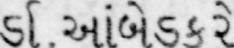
ર્ડા.આંબેડકરે
